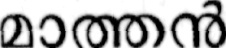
മാത്തന്‍
